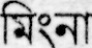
মিংনা
